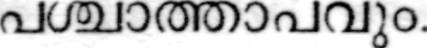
പശ്ചാത്താപവും.
